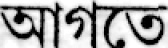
আগতে
